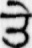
ਤੇ
